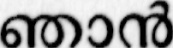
ഞാന്‍
